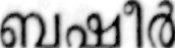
ബഷീര്‍
